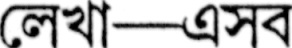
লেখা-এসব
